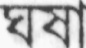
ঘষা
